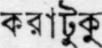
করাটুকু
